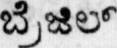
ಬ್ರೆಜಿಲ್
